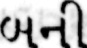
બની
